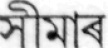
সীমাৰ
